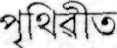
পৃথিৱীত
